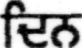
ਦਿਨ
